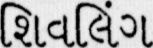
શિવલિંગ
